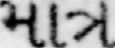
માત્ર
